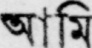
আমি
